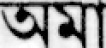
অমা
